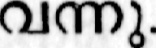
വന്നു.
